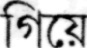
গিয়ে
